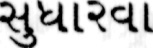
સુધારવા
